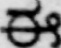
ಈ
